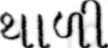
થાળી
